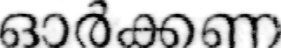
ഓര്‍ക്കണ
